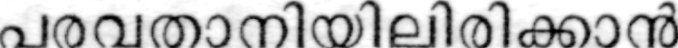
പരവതാനിയിലിരിക്കാന്‍
